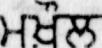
ਮਖ਼ੌਲ
